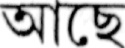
আছে
